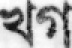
খগ
